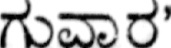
ಗುವಾರ'
